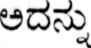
ಅದನ್ನು
